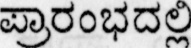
ಪ್ರಾರಂಭದಲ್ಲಿ
